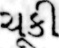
ચૂકી
